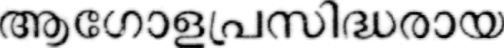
ആഗോളപ്രസിദ്ധരായ
